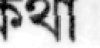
কথা
